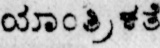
ಯಾಂತ್ರಿಕತೆ
